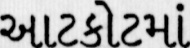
આટકોટમાં
